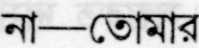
না–তোমার
